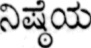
ನಿಷ್ಠೆಯ
